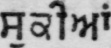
ਸੁਕੀਆਂ
